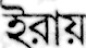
ইরায়
